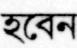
হবেন
